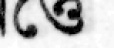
নত্তে
